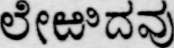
ಲೇಱಿದವು
